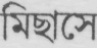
মিছাসে
